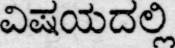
ವಿಷಯದಲ್ಲಿ
